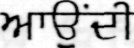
ਆਉਂਦੀ
